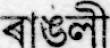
ৰাঙলী
